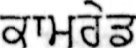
ਕਾਮਰੇਡ
